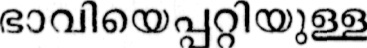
ഭാവിയെപ്പറ്റിയുള്ള
